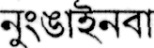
নুংঙাইনবা
